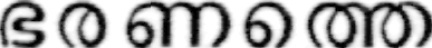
ഭരണത്തെ
